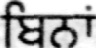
ਬਿਨਾਂ
